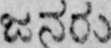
ಜನರು
